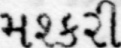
મશ્કરી
